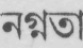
নগ্নতা
